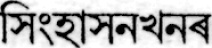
সিংহাসনখনৰ
